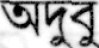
অদুবু
